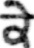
ਕੇ
